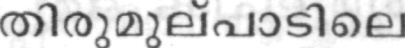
തിരുമുല്പാടിലെ
